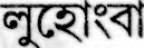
লুহোংবা
